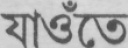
যাওঁতে
